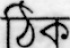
ঠিক
